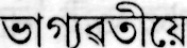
ভাগ্যৱতীয়ে
